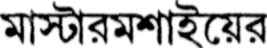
মাস্টারমশাইয়ের
